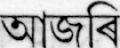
আজৰি
